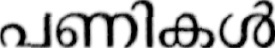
പണികള്‍
